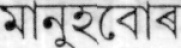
মানুহবোৰ
